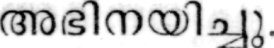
അഭിനയിച്ചു.
